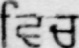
ਵਿਚ
